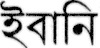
ইবানি
